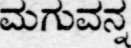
ಮಗುವನ್ನ
